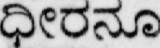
ಧೀರನೂ
